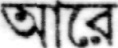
আরে
